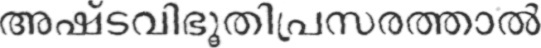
അഷ്ടവിഭൂതിപ്രസരത്താല്‍
